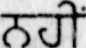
ਨਹੀਂ
